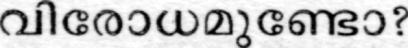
വിരോധമുണ്ടോ?
